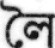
লৈ
